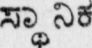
ಸ್ಥಾನಿಕ
